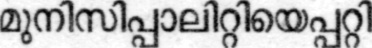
മുനിസിപ്പാലിറ്റിയെപ്പറ്റി
